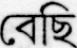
বেছি
